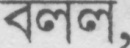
বলল,
